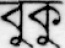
বুকু
